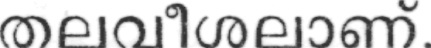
തലവീശലാണ്.
